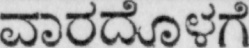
ವಾರದೊಳಗೆ
